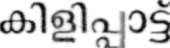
കിളിപ്പാട്ട്
